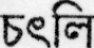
চৎলি
